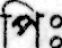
পিঃ
